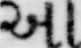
આ
